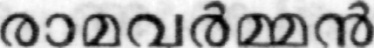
രാമവര്‍മ്മന്‍
